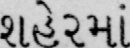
શહેરમાં
